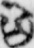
છે
